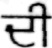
ਦੀ
